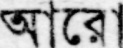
আরো
